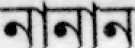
নানান
